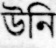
উনি
